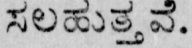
ಸಲಹುತ್ತವೆ.
